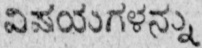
ವಿಷಯಗಳನ್ನು
